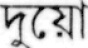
দুয়ো
